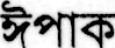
ঈপাক
